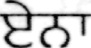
ਏਨਾ
